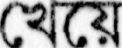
খেয়ে
